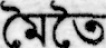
মৈতৈ
